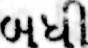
બધી
